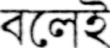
বলেই
